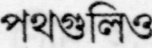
পথগুলিও
